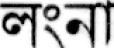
লংনা
